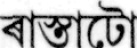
ৰাস্তাটো
